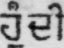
ਹੁੰਦੀ
